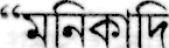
“মনিকাদি
